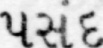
પસંદ
